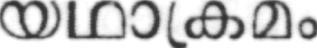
യഥാക്രമം
